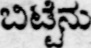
ಬಿಟ್ಟೆನು
